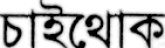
চাইথোক
